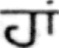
ਹਾਂ
